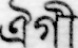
ঐগী
